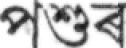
পশুৰ
